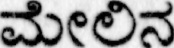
ಮೇಲಿನ
